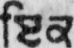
ਇਕ
